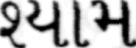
શ્યામ
